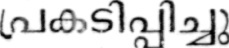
പ്രകടിപ്പിച്ചു
